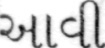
આવી
